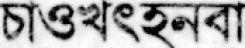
চাওখৎহনবা
